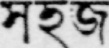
সহজ
